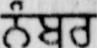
ਨੰਬਰ
